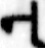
ન
